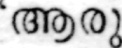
‘ആരു
